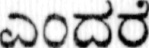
ಎಂದರೆ
